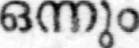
ഒന്നും
